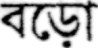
বড়ো
